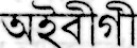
অইবীগী
